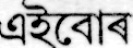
এইবোৰ
